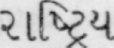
રાષ્ટ્રિય
